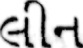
લીન
